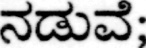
ನಡುವೆ;
